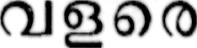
വളരെ
